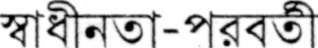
স্বাধীনতা-পরবর্তী
